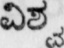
ವಿಶ್ವ
